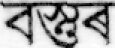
বস্তুৰ
